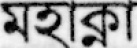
মহাক্না
